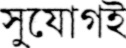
সুযোগই
